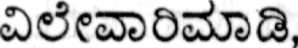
ವಿಲೇವಾರಿಮಾಡಿ,
